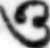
ও
